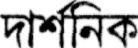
দার্শনিক
